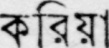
করিয়া
